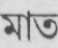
মাত
